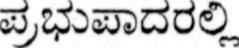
ಪ್ರಭುಪಾದರಲ್ಲಿ
